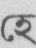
হে
